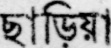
ছাড়িয়া
